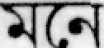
মনে
